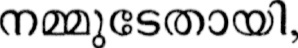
നമ്മുടേതായി,
